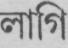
লাগি
